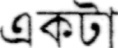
একটা
